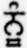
ਨੂੰ
